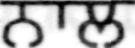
ਨਾਲ
